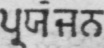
ਪ੍ਰਯੋਜਨ
